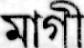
মাগী
